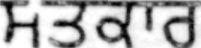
ਸਤਕਾਰ
